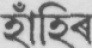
হাঁহিৰ
